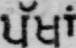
ਪੱਖਾਂ
